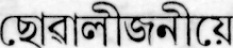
ছোৱালীজনীয়ে
